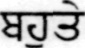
ਬਹੁਤੇ
